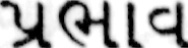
પ્રભાવ
